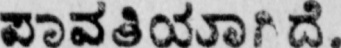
ಪಾವತಿಯಾಗಿದೆ.
